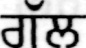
ਗੱਲ
